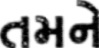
તમને
